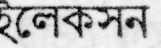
ইলেকসন
